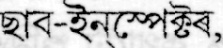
ছাব-ইন্‌স্পেক্টৰ,
